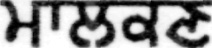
ਮਾਲਕਣ
